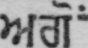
ਅਗੋਂ
